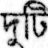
দুটি
